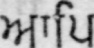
ਆਪਿ
